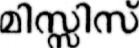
മിസ്സിസ്
